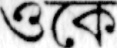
ওকে
